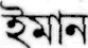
ইমান
